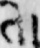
તો
